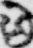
છે
